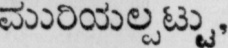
ಮುರಿಯಲ್ಪಟ್ಟು,
